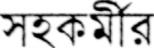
সহকর্মীর
